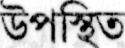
উপস্থিত
